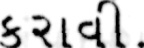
કરાવી.
